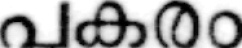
പകരം
